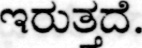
ಇರುತ್ತದೆ.
